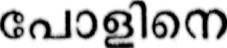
പോളിനെ
